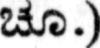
ಚೂ.)
